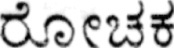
ರೋಚಕ
